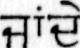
ਜਾਂਦੇ
